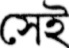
সেই
